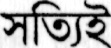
সত্যিই
